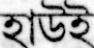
হাউই
